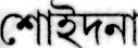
শোইদনা
